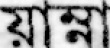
য়াম্না
